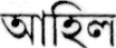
আহিল
